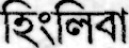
হিংলিবা
